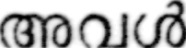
അവള്‍
